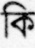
কি
